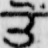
ਤੋਂ
